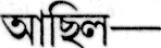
আছিল-
